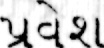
પ્રવેશ
